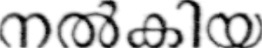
നല്‍കിയ
